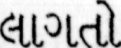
લાગતો
